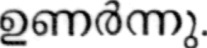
ഉണര്‍ന്നു.
